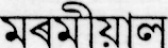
মৰমীয়াল
